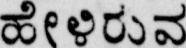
ಹೇಳಿರುವ
